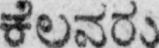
ಕೆಲವರು
